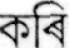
কৰি
